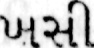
ખસી
